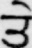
ਤੇ
